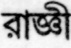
রাজ্ঞী
